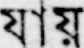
যায়
